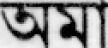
অমা
